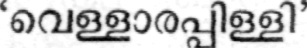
‘വെള്ളാരപ്പിള്ളി’
